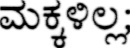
ಮಕ್ಕಳಿಲ್ಲ;
